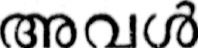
അവള്‍
